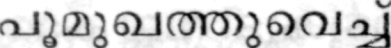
പൂമുഖത്തുവെച്ച്
